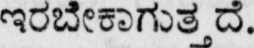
ಇರಬೇಕಾಗುತ್ತದೆ.
